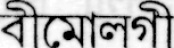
বীমোলগী
